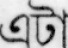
এটা
